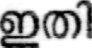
ഇതി
